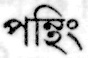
পন্থিং
